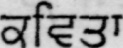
ਕਵਿਤਾ
